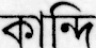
কান্দি
